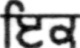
ਇਕ
